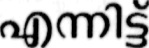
എന്നിട്ട്
